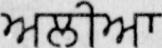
ਅਲੀਆ
